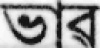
ভাৱ
